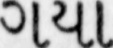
ગયા
